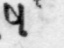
વર્ષ
